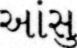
આંસુ
